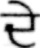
ਦੇ
